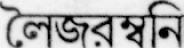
লৈজরম্বনি
